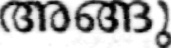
അങ്ങു
